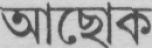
আছোক
